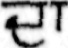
ਦਾ
